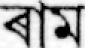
ৰাম
